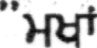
''ਮਖਾਂ
